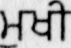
ਮੁਖੀ
